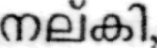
നല്കി,
